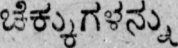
ಚೆಕ್ಕುಗಳನ್ನು
